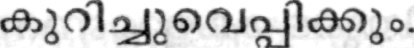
കുറിച്ചുവെപ്പിക്കും.
